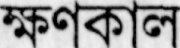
ক্ষণকাল
